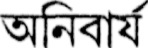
অনিবার্য
